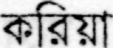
করিয়া
